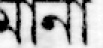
মানা
